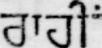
ਰਾਹੀਂ
